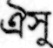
ঐসু
